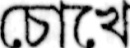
চোখে
